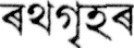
ৰথগৃহৰ
